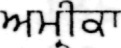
ਅਮ੍ਰੀਕਾ
